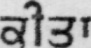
ਕੀਤਾ
